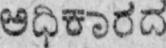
ಅಧಿಕಾರದ
